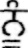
ਨੂੰ
